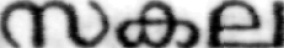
സകല
